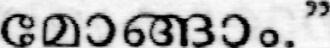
മോങ്ങാം."
